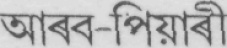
আৰব-পিয়াৰী
